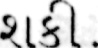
શકી.
